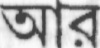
আর
